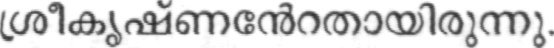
ശ്രീകൃഷ്ണന്റേതായിരുന്നു.
